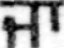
ਜਾ
